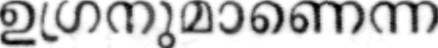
ഉഗ്രനുമാണെന്ന
